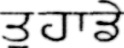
ਤੁਹਾਡੇ
